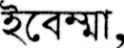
ইবেম্মা,
